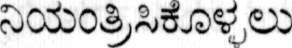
ನಿಯಂತ್ರಿಸಿಕೊಳ್ಳಲು
